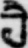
ਹੈ
